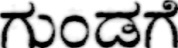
ಗುಂಡಗೆ
